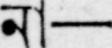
না—
